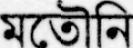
মতৌনি
